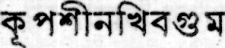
কূপশীনখিবগুম
